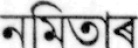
নমিতাৰ
